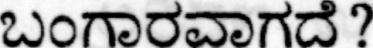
ಬಂಗಾರವಾಗದೆ?
